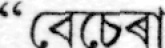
"বেচেৰা
